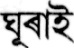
ঘূৰাই
